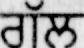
ਗੱਲ
